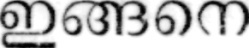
ഇങ്ങനെ
